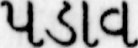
પડાવ
